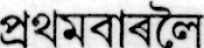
প্রথমবাৰলৈ
